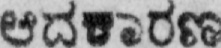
ಆದಕಾರಣ
